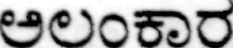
ಅಲಂಕಾರ
